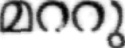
മററു
